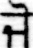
ਜੋ
